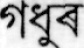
গধুৰ
